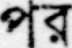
পর
